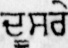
ਦੂਸਰੇ
